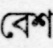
বেশ
